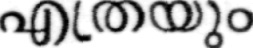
എത്രയും
